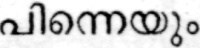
പിന്നെയും
